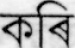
কৰি
